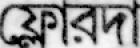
ফ্লোরদা
